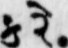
કરે.
